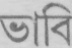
ভাবি
